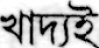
খাদ্যই
